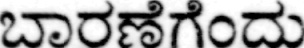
ಬಾರಣೆಗೆಂದು
